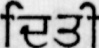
ਦਿਤੀ
